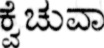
ಕ್ವೆಚುವಾ
